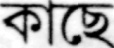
কাছে
